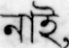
নাই,
